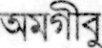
অমগীবু
